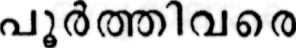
പൂര്‍ത്തിവരെ
